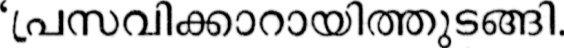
'പ്രസവിക്കാറായിത്തുടങ്ങി.
